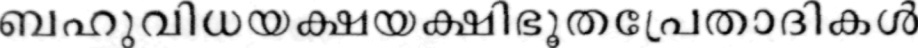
ബഹുവിധയക്ഷയക്ഷിഭൂതപ്രേതാദികള്‍
